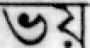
ভয়
